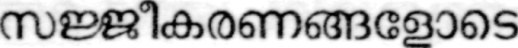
സജ്ജീകരണങ്ങളോടെ
